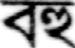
বহু
